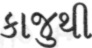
કાજુથી
